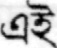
এই
